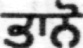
ਭਾਨੋ
